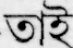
তাই
